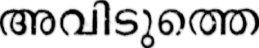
അവിടുത്തെ
